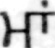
ਮਾਂ
